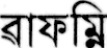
ৱাফম্নি
